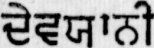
ਦੇਵਯਾਨੀ
